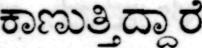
ಕಾಣುತ್ತಿದ್ದಾರೆ
